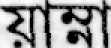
য়াম্না
